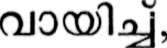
വായിച്ച്,
